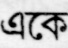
একে
